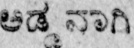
ಅಡ್ಡವಾಗಿ
